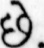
છે.
